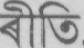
ৰীতি,
